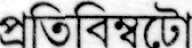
প্রতিবিম্বটো
